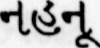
નહનૂ
